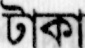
টাকা
